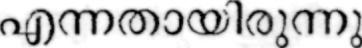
എന്നതായിരുന്നു
